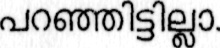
പറഞ്ഞിട്ടില്ലാ.
